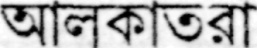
আলকাতরা
